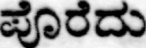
ಪೊರೆದು
